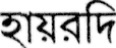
হায়রদি
